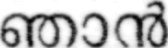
ഞാന്‍
